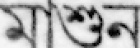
মাশুন
